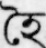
হৈ
